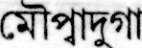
মৌপ্বাদুগা
